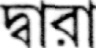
দ্বারা
